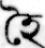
হৈ
